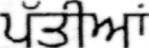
ਪੱਤੀਆਂ
